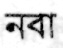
নবা
